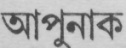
আপুনাক
